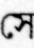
সে
